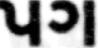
પગ
